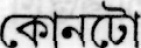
কোনটো
